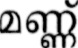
മണ്ണ്
